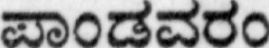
ಪಾಂಡವರಂ
